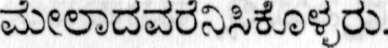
ಮೇಲಾದವರೆನಿಸಿಕೊಳ್ಳರು.
